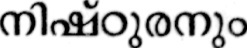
നിഷ്ഠുരനും
